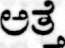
ಅತ್ತೆ
